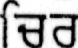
ਚਿਰ
